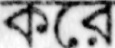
করে
